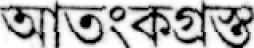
আতংকগ্রস্ত
